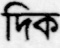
দিক
